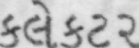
કલેકટર
